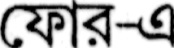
ফোর-এ
